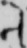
ને
